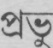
প্ৰভু
